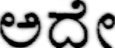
ಅದೇ
